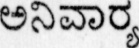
ಅನಿವಾರ್‍ಯ
